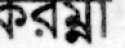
করম্না
